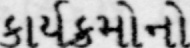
કાર્યક્રમોનો
